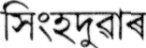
সিংহদুৱাৰ
